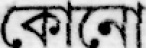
কোনো
